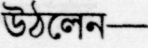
উঠলেন–
